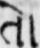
તો
